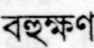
বহুক্ষণ
